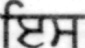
ਇਸ
